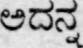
ಅದನ್ನ
